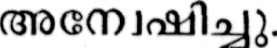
അന്വേഷിച്ചു.
